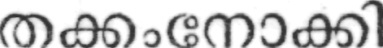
തക്കംനോക്കി
